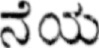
ನೆಯ
